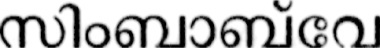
സിംബാബ്വേ
